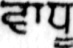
ਵਾਧੂ
